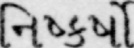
નિષ્કર્ષો
